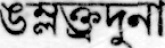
ঙম্লক্ত্রদুনা
